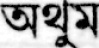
অথুম
